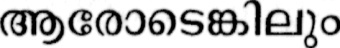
ആരോടെങ്കിലും
